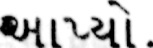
આપ્યો.
